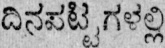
ದಿನಪಟ್ಟಿಗಳಲ್ಲಿ
